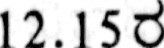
12.15ರ
